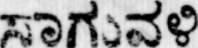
ಸಾಗುವಳಿ
